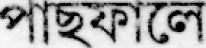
পাছফালে
